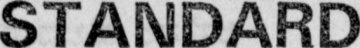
STANDARD
